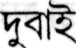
দুবাই
